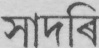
সাদৰি
